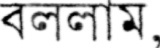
বললাম,
